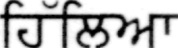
ਹਿੱਲਿਆ
